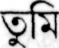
তুমি
